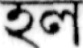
হল
